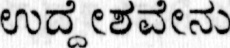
ಉದ್ದೇಶವೇನು
